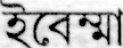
ইবেম্মা
